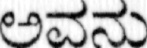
ಅವನು
